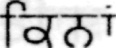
ਕਿਨਾਂ
